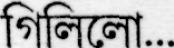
গিলিলো...
